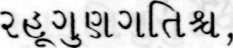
રહૂગુણગતિશ્ચ,
